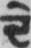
ਦੇ
